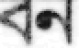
বন
